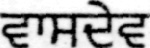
ਵਾਸਦੇਵ
